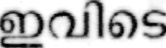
ഇവിടെ
